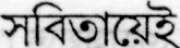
সবিতায়েই
